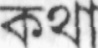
কথা
